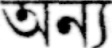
অন্য
